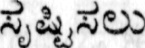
ಸೃಷ್ಟಿಸಲು
